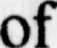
of
